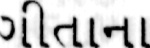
ગીતાના
